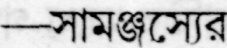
–সামঞ্জস্যের
